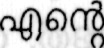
എന്റെ
